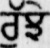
ਰੁੱਝੇ
